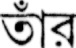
তাঁর
